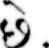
છે.
